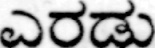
ಎರಡು
